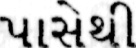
પાસેથી
